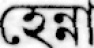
হেন্না
